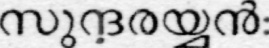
സുന്ദരയ്യന്‍:
